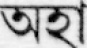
অহা
